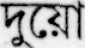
দুয়ো
